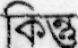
কিন্তু
